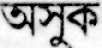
অসুক
